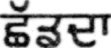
ਛੱਡਦਾ
